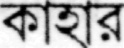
কাহার
